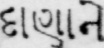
દાણાને
